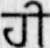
ਹੀ
